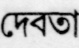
দেবতা
